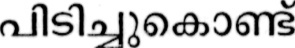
പിടിച്ചുകൊണ്ട്
